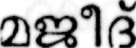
മജീദ്
